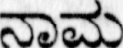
ನಾಮ
